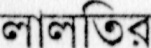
লালতির
